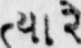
ત્યારે
